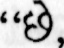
"છે,
